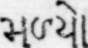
મળ્યો
